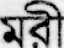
মরী
